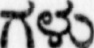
ಗಳು
